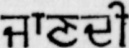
ਜਾਣਦੀ
